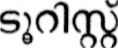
ടൂറിസ്റ്റ്
